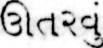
ઊતરવું
